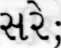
સરે;
